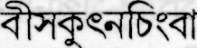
বীসকুৎনচিংবা
